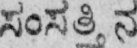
ಸಂಸತ್ತಿನ
